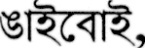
ঙাইবোই,
